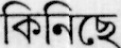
কিনিছে
